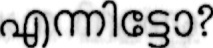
എന്നിട്ടോ?
